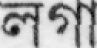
লগা
